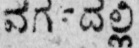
ವರ್ಗದಲ್ಲಿ
